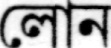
লোন
